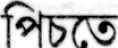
পিচতে
